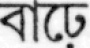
বাঢ়ে
